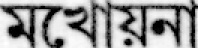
মখোয়না
